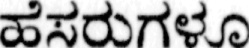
ಹೆಸರುಗಳೂ
